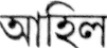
আহিল
